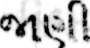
જાણી
